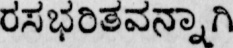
ರಸಭರಿತವನ್ನಾಗಿ
